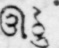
ઊઠું
